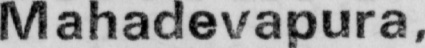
Mahadevapura,
